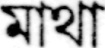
মাথা
